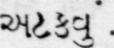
અટકવું.
